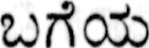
ಬಗೆಯ
